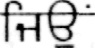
ਜਿਉਂ
